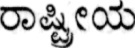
ರಾಷ್ಟ್ರೀಯ
